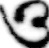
ও
